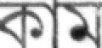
কাম
